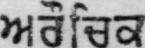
ਅਰੌਚਿਕ
